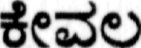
ಕೇವಲ
